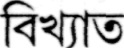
বিখ্যাত
